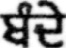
ਬੰਦੇ
